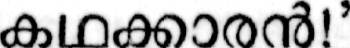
കഥക്കാരന്‍!'
